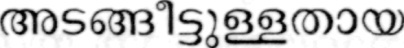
അടങ്ങീട്ടുള്ളതായ
